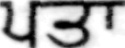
ਪਤਾ
